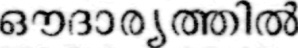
ഔദാര്യത്തില്‍
